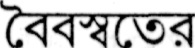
বৈবস্বতের
